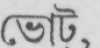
ভোট্‌,
